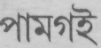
পামগই
